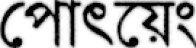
পোৎয়েং
